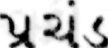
પ્રચંડ
